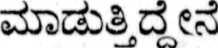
ಮಾಡುತ್ತಿದ್ದೇನೆ
